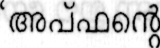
'അപ്ഫന്റെ
